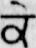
ਕੇ
